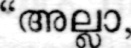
“അല്ലാ,
